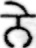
ਨੇ
